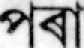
পৰা
